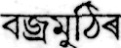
বজ্ৰমুঠিৰ
